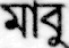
মাবু
